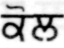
ਕੋਲ
